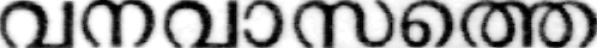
വനവാസത്തെ
